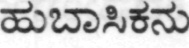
ಹುಬಾಸಿಕನು
